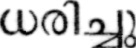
ധരിച്ചു
